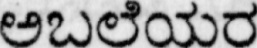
ಅಬಲೆಯರ
